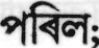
পৰিল;
